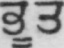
ਭੂਤ
